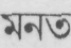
মনত
